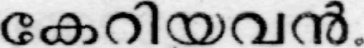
കേറിയവന്‍.
